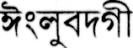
ঈংলুবদগী
